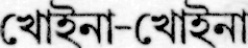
খোইনা-খোইনা
